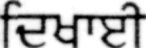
ਦਿਖਾਈ
